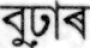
বুঢ়াৰ
